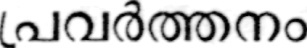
പ്രവര്‍ത്തനം
